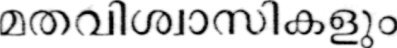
മതവിശ്വാസികളും
